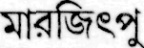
মারজিৎপু
